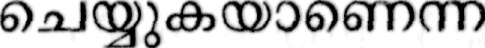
ചെയ്യുകയാണെന്ന
